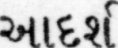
આદર્શ
